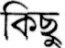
কিছু
